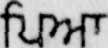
ਪਿਆ
